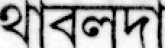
থাবলদা
